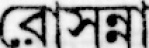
রোসন্না
